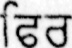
ਫਿਰ
